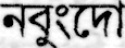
নবুংদো
